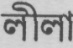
লীলা
